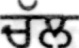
ਚੱਲ
